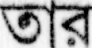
তার
